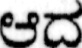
ಆದ
